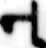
ન
